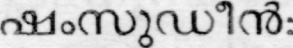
ഷംസുഡീന്‍:
